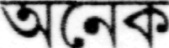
অনেক
